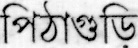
পিঠাগুড়ি
